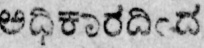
ಅಧಿಕಾರದಿಂದ
